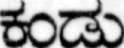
ಕಂಡು
